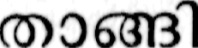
താങ്ങി
